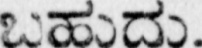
ಬಹುದು.
